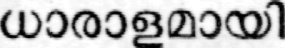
ധാരാളമായി
